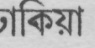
ঢাকিয়া
